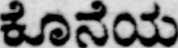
ಕೊನೆಯ
